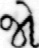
જો
